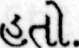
હતો.
